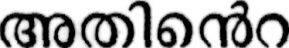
അതിന്റെ
